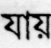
যায়
